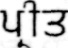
ਪ੍ਰੀਤ
